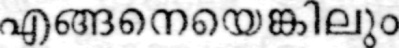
എങ്ങനെയെങ്കിലും
